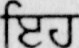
ਇਹ
